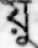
য়ু
